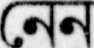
নেন
